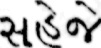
સહેજે
